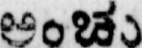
ಅಂಚು
